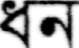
ধন
